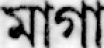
মাগা
